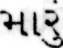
મારું
